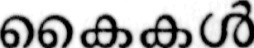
കൈകള്‍
